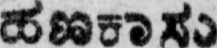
ಹಣಕಾಸು
